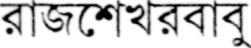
রাজশেখরবাবু
